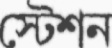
স্টেশন
